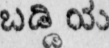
ಬಡ್ಡಿಯ
